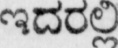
ಇದರಲ್ಲಿ
